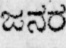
ಜನರ
